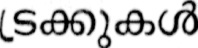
ട്രക്കുകള്‍
